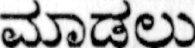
ಮಾಡಲು
